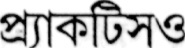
প্র্যাকটিসও
